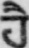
ਹੈ
